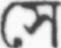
সে
